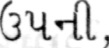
ઉપની,
